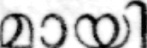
മായി
